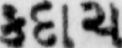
કદાચ
